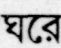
ঘরে
